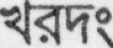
খরদং
